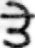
ਤੇ
